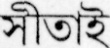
সীতাই
